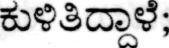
ಕುಳಿತಿದ್ದಾಳೆ;
